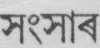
সংসাৰ
